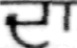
ਦਾ
